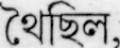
থৈছিল,
